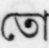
তো
